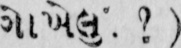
ગોખેલું?)
